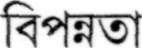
বিপন্নতা
